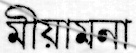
মীয়ামনা
